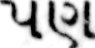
પણ
